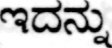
ಇದನ್ನು
